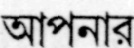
আপনার
